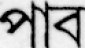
পাব
